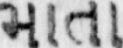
માતા
